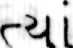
ત્યાં
